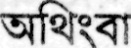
অথিংবা
